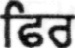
ਫਿਰ
